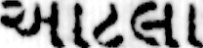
આટલા
